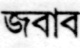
জবাব
